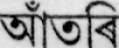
আঁতৰি
